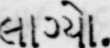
લાગ્યો.
